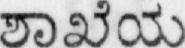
ಶಾಖೆಯ
